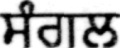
ਸੰਗਲ
